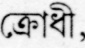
ক্রোধী,
